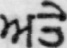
ਅਤੇ
